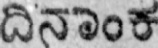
ದಿನಾಂಕ
